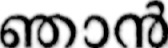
ഞാന്‍
